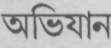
অভিযান
